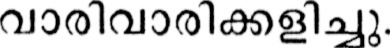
വാരിവാരിക്കളിച്ചു.
